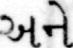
અને
